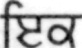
ਇਕ
